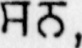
ਸਨ,
